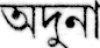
অদুনা
